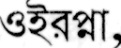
ওইরপ্না,
